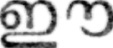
ഈ
